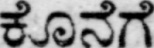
ಕೊನೆಗೆ
